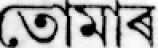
তোমাৰ
